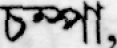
চম্পা,
